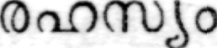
രഹസ്യം
